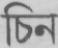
চিন
